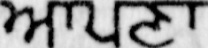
ਆਪਣਾ
